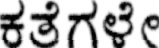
ಕತೆಗಳೇ
